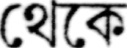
থেকে
